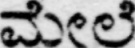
ಮೇಲೆ
